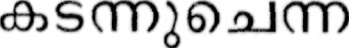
കടന്നുചെന്ന
